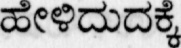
ಹೇಳಿದುದಕ್ಕೆ
